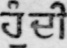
ਹੁੰਦੀ
